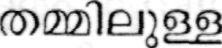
തമ്മിലുള്ള
